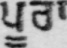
ਪੂਰਾ
